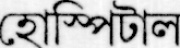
হোস্পিটাল
